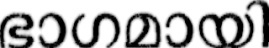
ഭാഗമായി
